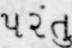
પરંતુ
